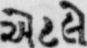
એટલે
